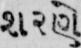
શરણે
